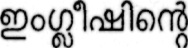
ഇംഗ്ലീഷിന്റെ
